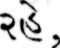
રહે,
